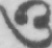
ও
